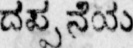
ದಪ್ಪನೆಯ
